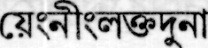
য়েংনীংলক্তদুনা
